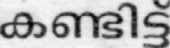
കണ്ടിട്ട്
